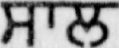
ਸਾਲ
